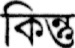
কিন্তু
